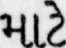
માટે
